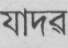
যাদৱ
